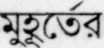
মুহূর্তের
